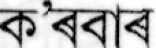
ক'ৰবাৰ
